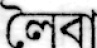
লৈবা
